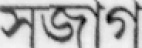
সজাগ
